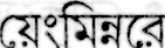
য়েংমিন্নরে
